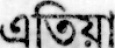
এতিয়া
